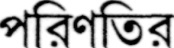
পরিণতির
